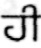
ਹੀ
